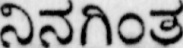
ನಿನಗಿಂತ
